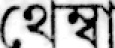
থেম্বা
